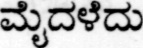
ಮೈದಳೆದು
